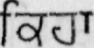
ਕਿਹਾ
